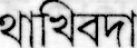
থাখিবদা
